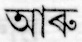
আৰু
